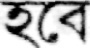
হবে
